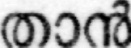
താന്‍
